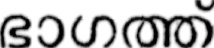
ഭാഗത്ത്
